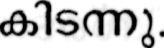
കിടന്നു.
